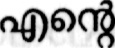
എന്റെ
